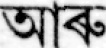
আৰু
